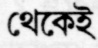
থেকেই
